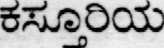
ಕಸ್ತೂರಿಯ
